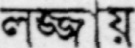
লজ্জায়
